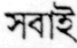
সবাই
